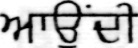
ਆਉਂਦੀ
